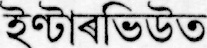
ইণ্টাৰভিউত
